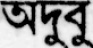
অদুবু
